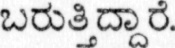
ಬರುತ್ತಿದ್ದಾರೆ.
